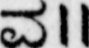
ವ||
